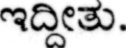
ಇದ್ದೀತು.
